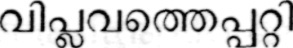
വിപ്ലവത്തെപ്പറ്റി
